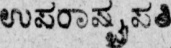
ಉಪರಾಷ್ಟ್ರಪತಿ
